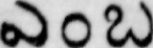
ಎಂಬ
